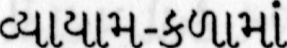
વ્યાયામ-કળામાં
